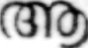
ആ
